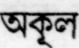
অকূল
